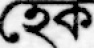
হেক
